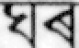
ঘৰ
